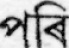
পৰি
